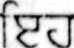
ਇਹ
